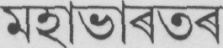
মহাভাৰতৰ
